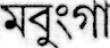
মবুংগা
